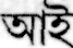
আই
